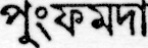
পুংফমদা
